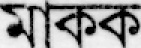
মাকক
